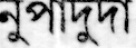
নুপাদুদা
